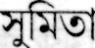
সুমিতা
